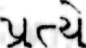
પ્રત્યે
